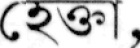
হেক্তা,
